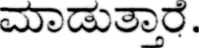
ಮಾಡುತ್ತಾರೆ.
